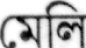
মেলি
